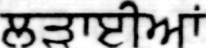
ਲੜਾਈਆਂ
